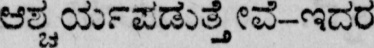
ಆಶ್ಚರ್ಯಪಡುತ್ತೇವೆ-ಇದರ
